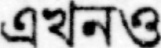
এখনও
